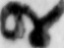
જ
